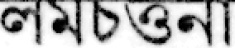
লমচত্তনা
